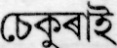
চেকুৰাই
